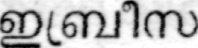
ഇബ്രീസ
